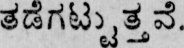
ತಡೆಗಟ್ಟುತ್ತವೆ.
